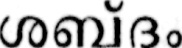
ശബ്ദം
